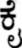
ಕೈ
